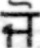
ਜੋ
